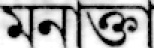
মনাক্তা
